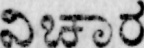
ವಿಚಾರ
